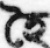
হৈ
